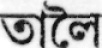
তালৈ
